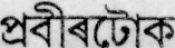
প্রবীৰটোক
